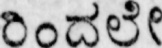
ರಿಂದಲೇ
